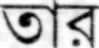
তার
